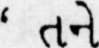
'તને
